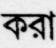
করা
